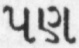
પણ
